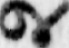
જ
